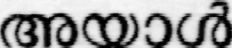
അയാള്‍
